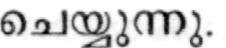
ചെയ്യുന്നു.
